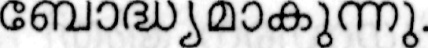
ബോദ്ധ്യമാകുന്നു.
